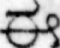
ಈ
